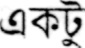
একটু
